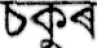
চকুৰ
